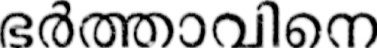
ഭര്‍ത്താവിനെ
